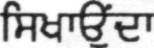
ਸਿਖਾਉਂਦਾ
